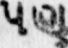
પણ
